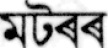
মটৰৰ
